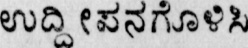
ಉದ್ದೀಪನಗೊಳಿಸಿ
